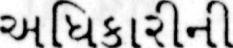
અધિકારીની
